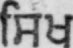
ਸਿਖ
